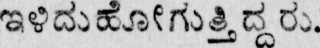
ಇಳಿದುಹೋಗುತ್ತಿದ್ದರು.
